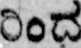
ರಿಂದ
